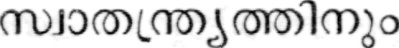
സ്വാതന്ത്ര്യത്തിനും
